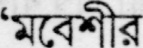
‘মবেশীর
